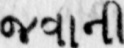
જવાની
